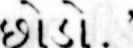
છોડો.'
